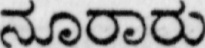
ನೂರಾರು
